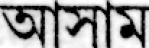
আসাম
